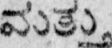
ಮತ್ತು
